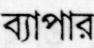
ব্যাপার
